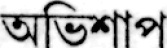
অভিশাপ
